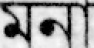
মনা
